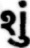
શું
